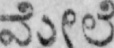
ಮೇಲೆ
